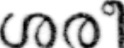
ശരീ
